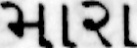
મારા
